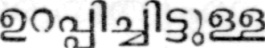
ഉറപ്പിച്ചിട്ടുള്ള
